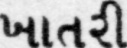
ખાતરી
